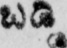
ಬಡ್ಡಿ
